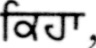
ਕਿਹਾ,
